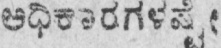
ಅಧಿಕಾರಗಳಷ್ಟೇ
